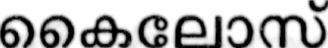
കൈലോസ്
